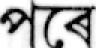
পৰে
